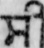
ਸੀ
